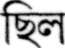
ছিল
